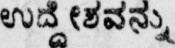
ಉದ್ದೇಶವನ್ನು
